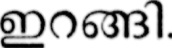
ഇറങ്ങി.
